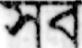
সব
